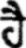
ਹੈ
